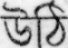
উঠি
